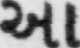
આ
